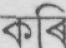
কৰি
